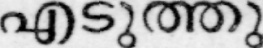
എടുത്തു
